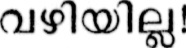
വഴിയില്ല!
